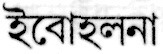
ইবোহলনা
